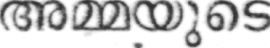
അമ്മയുടെ
